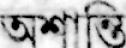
অশান্তি
